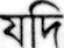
যদি
